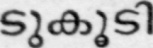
ടുകൂടി
